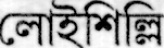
লোইশিল্লি
